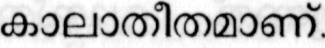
കാലാതീതമാണ്.
